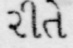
રીતે
